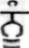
ਨੂੰ
